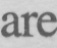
are
